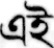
এই
